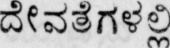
ದೇವತೆಗಳಲ್ಲಿ
